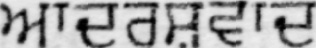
ਆਦਰਸ਼ਵਾਦ
